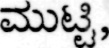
ಮುಟ್ಟಿ,
